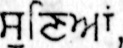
ਸੁਣਿਆਂ,
